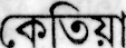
কেতিয়া
